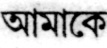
আমাকে
